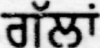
ਗੱਲਾਂ
